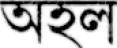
অহল
